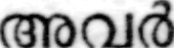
അവര്‍
